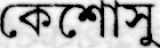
কেশোসু
